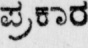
ಪ್ರಕಾರ
